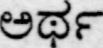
ಅರ್ಥ
